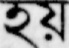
হয়
